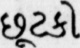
છૂટકો
